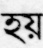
হয়
